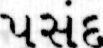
પસંદ
